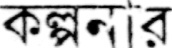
কল্পনার
